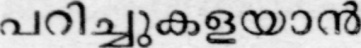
പറിച്ചുകളയാന്‍
